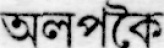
অলপকৈ
